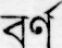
বর্ণ
